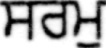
ਸਰਮੁ
